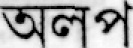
অলপ
